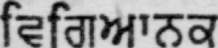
ਵਿਗਿਆਨਕ
